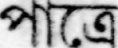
পাত্রে
